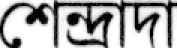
শেন্দ্রাদা
